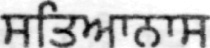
ਸਤਿਆਨਾਸ
